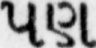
પણ
